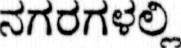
ನಗರಗಳಲ್ಲಿ
